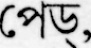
পেড্‌,
